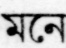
মনে
